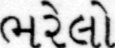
ભરેલો
